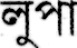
লুপা
